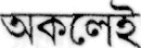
অকলেই
